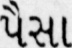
પૈસા
